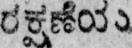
ರಕ್ಷಣೆಯ
